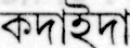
কদাইদা
